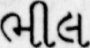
ભીલ
